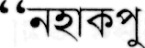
“নহাকপু
